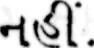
નહીં.
